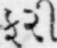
ફરી
